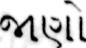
જાણો
